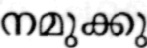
നമുക്കു
